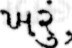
ખરું,
